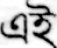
এই
